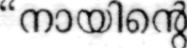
“നായിന്റെ
